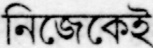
নিজেকেই
